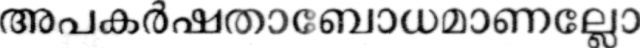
അപകര്‍ഷതാബോധമാണല്ലോ
